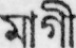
মাগী
